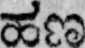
ಹಣ
